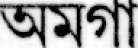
অমগা
